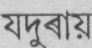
যদুৰায়
